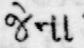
જેના
